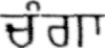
ਚੰਗਾ
